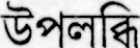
উপলব্ধি
